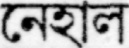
নেহাল
